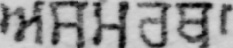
ਅਸਮਰਥਾ
